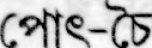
পোৎ-চৈ
